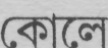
কোলে
